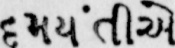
દમયંતીએ
